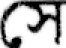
সে
